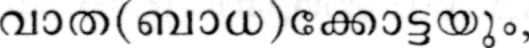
വാത(ബാധ)ക്കോട്ടയും,
